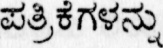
ಪತ್ರಿಕೆಗಳನ್ನು
